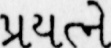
પ્રયત્ને
